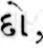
દો,
